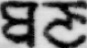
ਬਣ
